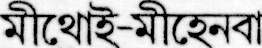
মীথোই-মীহেনবা
